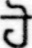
ਹੋ
